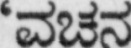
‘ವಚನ
